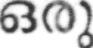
ഒരു
